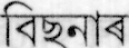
বিছনাৰ
